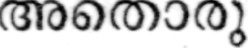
അതൊരു
